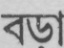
বড়া
